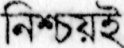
নিশ্চয়ই
